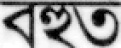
বহুত
